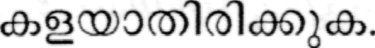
കളയാതിരിക്കുക.
